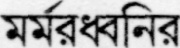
মর্মরধ্বনির
